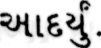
આદર્યું.
